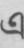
এ
